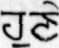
ਹੁਣੇ
